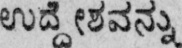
ಉದ್ದೇಶವನ್ನು
